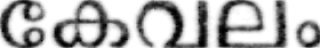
കേവലം
